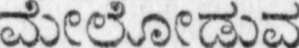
ಮೇಲೋಡುವ
